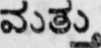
ಮತ್ತು
